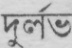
দুৰ্লভ
